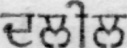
ਦਲੀਲ
